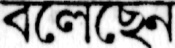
বলেছেন
